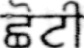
ਛੋਟੀ
